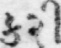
કરી
